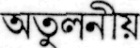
অতুলনীয়
